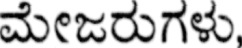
ಮೇಜರುಗಳು,
